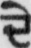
ਦੇ
